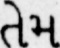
તેમ
